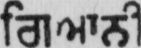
ਗਿਆਨੀ
